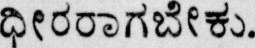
ಧೀರರಾಗಬೇಕು.
